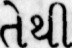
તેથી
